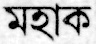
মহাক
